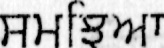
ਸਮਝਿਆ
